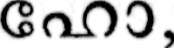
ഹോ,
